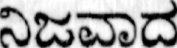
ನಿಜವಾದ
